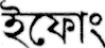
ইফোং
